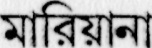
মারিয়ানা
